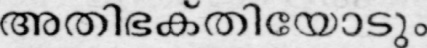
അതിഭക്തിയോടും
